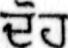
ਦੋਹ
